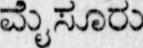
ಮೈಸೂರು
